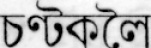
চণ্টকলৈ
